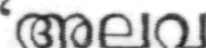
'അലവ
